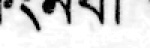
ফংনবা
